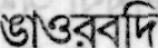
ঙাওরবদি
